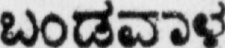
ಬಂಡವಾಳ
